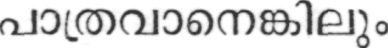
പാത്രവാനെങ്കിലും
